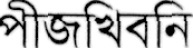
পীজখিবনি
